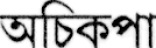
অচিকপা
